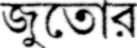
জুতোর
